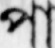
পা
